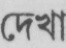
দেখা
